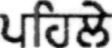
ਪਹਿਲੇ
